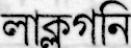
লাক্লগনি
